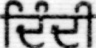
ਦਿੰਦੀ
